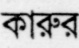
কারুর
